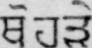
ਥੋਹੜੇ
